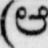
(ಆ
